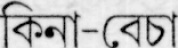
কিনা-বেচা
